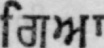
ਗਿਆ
